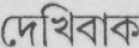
দেখিবাক
